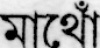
মাথোঁ
